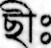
ছীঃ
